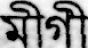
মীগী
